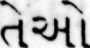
તેઓ
